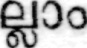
ല്ലാം
